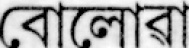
বোলোৱা
